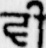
ਵੀ
